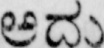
ಅದು
